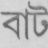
বাট
